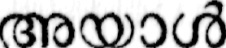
അയാള്‍
